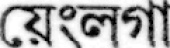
য়েংলগা
